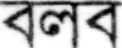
বলব
